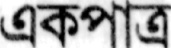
একপাত্র
